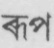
ৰূপ
